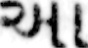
આ
